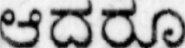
ಆದರೂ
